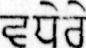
ਵਧੇਰੇ
